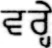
ਵਰ੍ਹੇ
